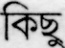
কিছু
